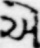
એ
